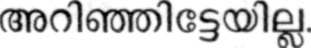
അറിഞ്ഞിട്ടേയില്ല.
